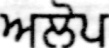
ਅਲੋਪ
